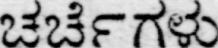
ಚರ್ಚೆಗಳು
